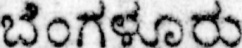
ಬೆಂಗಳೂರು
